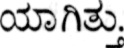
ಯಾಗಿತ್ತು.
